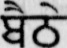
ਬੈਠੇ
